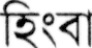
হিংবা
